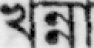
খন্না
